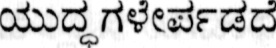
ಯುದ್ಧಗಳೇರ್ಪಡದೆ
